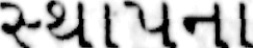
સ્થાપના
